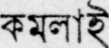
কমলাই
